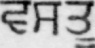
ਵਸਤੂ
